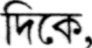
দিকে,
